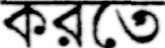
করতে
